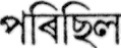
পৰিছিল
